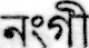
নংগী
